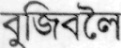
বুজিবলৈ
